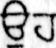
ਉਹ
